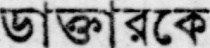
ডাক্তারকে
